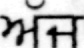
ਅੱਜ
